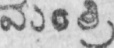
ಮಂತ್ರಿ
